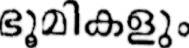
ഭൂമികളും
